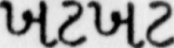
ખટખટ
